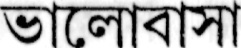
ভালোবাসা
